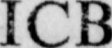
ICB
